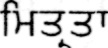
ਮਿਤ੍ਰਤਾ
